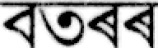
বতৰৰ
